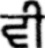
ਵੀ
